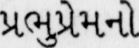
પ્રભુપ્રેમનો
